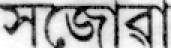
সজোৱা
